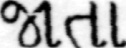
જાતા
